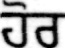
ਹੋਰ
